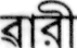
ৱারী
